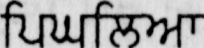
ਪਿਘਲਿਆ
